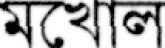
মখোল
